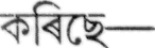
কৰিছে-
